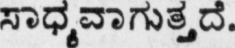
ಸಾಧ್ಯವಾಗುತ್ತದೆ.
